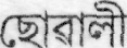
ছোৱালী
